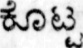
ಕೊಟ್ಟ
